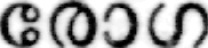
രോഗ
